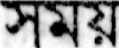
সময়
